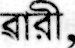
ৱারী,
